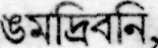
ঙমদ্রিবনি,
